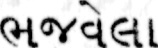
ભજવેલા
